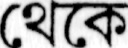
থেকে
